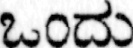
ಒಂದು
